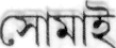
সোমাই
